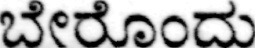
ಬೇರೊಂದು
